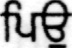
ਪਿਉ
